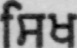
ਸਿਖ
